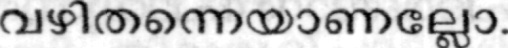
വഴിതന്നെയാണെല്ലോ.
